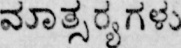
ಮಾತ್ಸರ್‍ಯಗಳು
